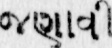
જણાવી
